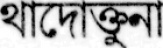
থাদোক্তুনা
